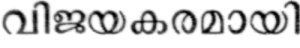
വിജയകരമായി
